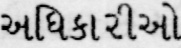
અધિકારીઓ
